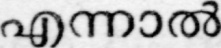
എന്നാല്‍
